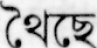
থৈছে
